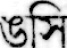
ঙসি
